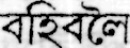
বহিবলৈ
